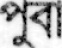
পুবা
